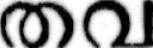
തവ
